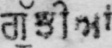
ਗੁੱਝੀਆਂ
